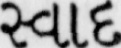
સ્વાદ
